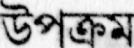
উপক্রম
